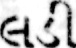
લડી
